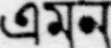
এমন
